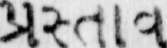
પ્રસ્તાવ
